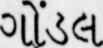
ગોંડલ
